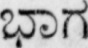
ಭಾಗ
